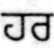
ਹਰ
